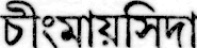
চীংমায়সিদা
